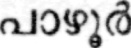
പാഴൂര്‍
